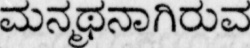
ಮನ್ಮಥನಾಗಿರುವ
